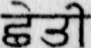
ਛੇਤੀ
